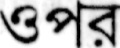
ওপর
